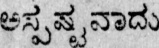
ಅಸ್ಪಷ್ಟವಾದು
